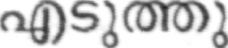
എടുത്തു
